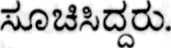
ಸೂಚಿಸಿದ್ದರು.
